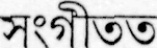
সংগীতত
